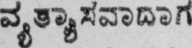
ವ್ಯತ್ಯಾಸವಾದಾಗ
